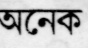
অনেক
